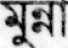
মুন্না
